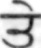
ਤੇ
